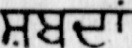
ਸ਼ਬਦਾਂ
